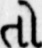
તો
